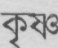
কৃষ্ণ
